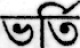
ভর্তি
